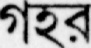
গহর
